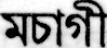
মচাগী
